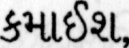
કમાઈશ,
